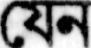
যেন
